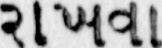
રાખવા
